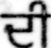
ਦੀ
